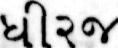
ધીરજ
